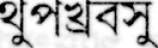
থুপখ্রবসু
